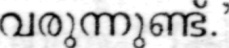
വരുന്നുണ്ട്.’
